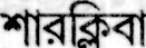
শারক্লিবা
